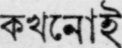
কখনোই
